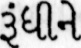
રૂંધીને
